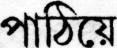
পাঠিয়ে
